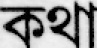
কথা
